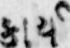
કાર્ય
